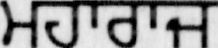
ਮਹਾਰਾਜ
